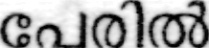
പേരില്‍
